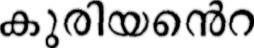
കുരിയന്റെ
